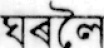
ঘৰলৈ
